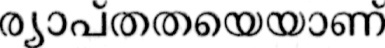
ര്യാപ്തതയെയാണ്
